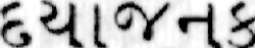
દયાજનક
